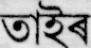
তাইৰ
